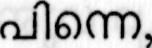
പിന്നെ,
